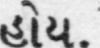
હોય.
